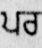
ਪਰ
